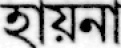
হায়না
